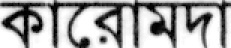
কারোমদা
